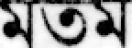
মতম
